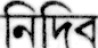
নিদিব
